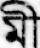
মী
